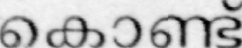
കൊണ്ട്
